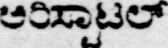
ಅರಿಸ್ಟಾಟಲ್
